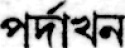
পর্দাখন
